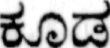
ಕೂಡ
